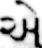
એ
